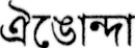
ঐঙোন্দা
